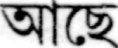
আছে
